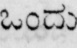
ಒಂದು
